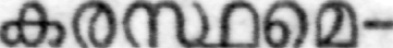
കരസ്ഥമെ-
